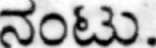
ನಂಟು.
